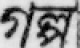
গল্প
